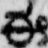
ಈ
